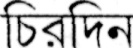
চিরদিন
